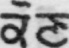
ਕੋਣ
